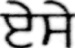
ਏਸੇ
